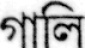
গালি
